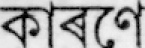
কাৰণে
